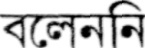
বলেননি
